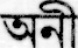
অনী
